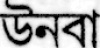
উনবা
